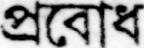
প্রবোধ
